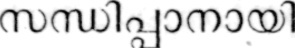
സന്ധിപ്പാനായി
